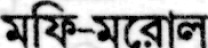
মফি-মরোল
